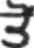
ਤੋਂ
